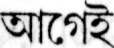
আগেই
